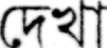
দেখা
